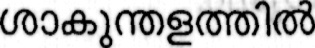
ശാകുന്തളത്തില്‍
